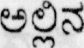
ಅಲ್ಲಿನ
